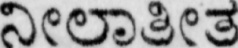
ನೀಲಾತೀತ
